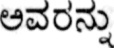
ಅವರನ್ನು
